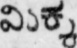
ಮಿಕ್ಕ
